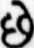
છે
